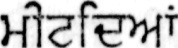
ਮੀਟਦਿਆਂ
